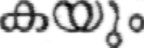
കയും
